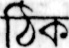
ঠিক
